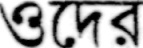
ওদের
